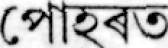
পোহৰত
